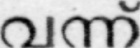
വന്ന്
